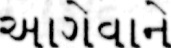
આગેવાને
